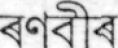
ৰণবীৰ
